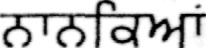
ਨਾਨਕਿਆਂ
